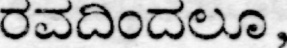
ರವದಿಂದಲೂ,
